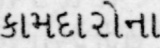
કામદારોના
